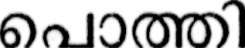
പൊത്തി
